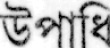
উপাধি
